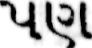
પણ
